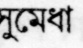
সুমেধা
